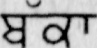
ਬੱਕਾ
